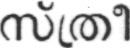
സ്ത്രീ
